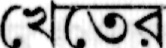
খেতের
